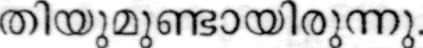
തിയുമുണ്ടായിരുന്നു.
